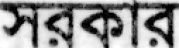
সরকার
